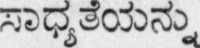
ಸಾಧ್ಯತೆಯನ್ನು
